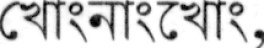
খোংনাংখোং,
